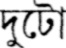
দুটো
